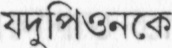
যদুপিওনকে
